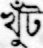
খুঁট
